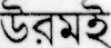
উরমই
